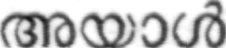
അയാള്‍
